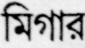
মিগার
